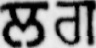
ਲਗ
